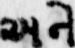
અને
